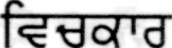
ਵਿਚਕਾਰ
